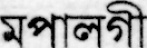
মপালগী
